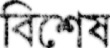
বিশেষ
